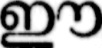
ഈ
